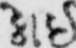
કોઈ
